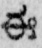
ಈ
